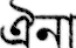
ঐনা
